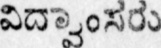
ವಿದ್ವಾಂಸರು
